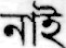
নাই
